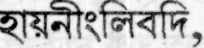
হায়নীংলিবদি,
